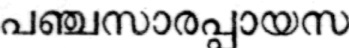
പഞ്ചസാരപ്പായസ
